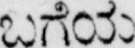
ಬಗೆಯ
